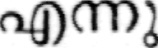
എന്നു
